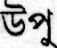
উপু
